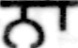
ਨਾ
